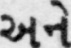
અને
